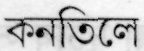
কনতিলে
